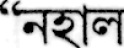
“নহাল
